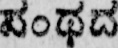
ಪಂಥದ
